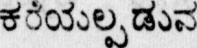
ಕರೆಯಲ್ಪಡುವ
